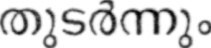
തുടര്‍ന്നും
